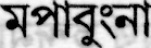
মপাবুংনা
